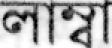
লাম্বা
